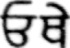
ਓਥੇ
